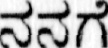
ನನಗೆ
